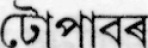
টোপাবৰ
